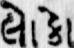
લોકો
